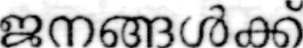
ജനങ്ങള്‍ക്ക്
